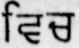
ਵਿਚ
